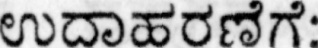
ಉದಾಹರಣೆಗೆ:
